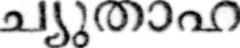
ച്യുതാഹ
